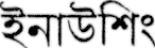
ইনাও
